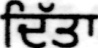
ਦਿੱਤਾ
